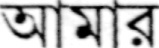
আমার
